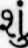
શું
